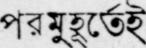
পরমুহূর্তেই
